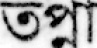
তপ্না
